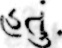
હતું.
